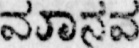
ಮಾನವ
